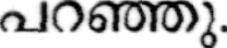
പറഞ്ഞു.
